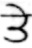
ਤੇ
